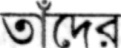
তাঁদের
